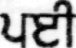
ਪਈ
